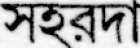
সহরদা
